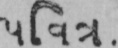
પવિત્ર
